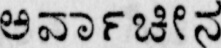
ಅರ್ವಾಚೀನ
